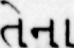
તેના
